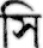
সি
